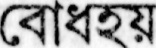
বোধহয়
